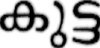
കുട്ട
